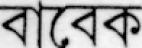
বাবেক
